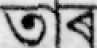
তাৰ
